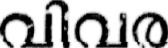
വിവര
